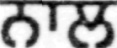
ਨਾਲ
